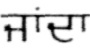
ਜਾਂਦਾ
